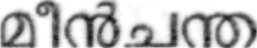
മീന്‍ചന്ത
